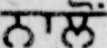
ਨਾਲੋਂ
